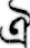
ঐ
